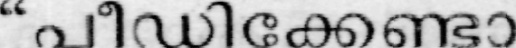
"പീഡിക്കേണ്ടാ
